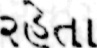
રહેતા
